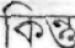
কিন্তু
